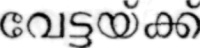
വേട്ടയ്ക്ക്
